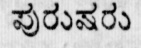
ಪುರುಷರು
